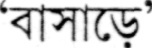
‘বাসাড়ে’
